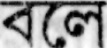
বলে
